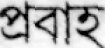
প্রবাহ
